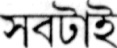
সবটাই
